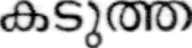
കടുത്ത
